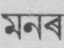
মনৰ
